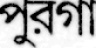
পুরগা
